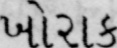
ખોરાક
